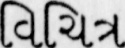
વિચિત્ર
